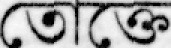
তোক্তে
